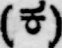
(ಕ)
